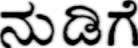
ನುಡಿಗೆ
